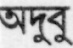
অদুবু
